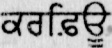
ਕਰਫ਼ਿਊ
